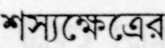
শস্যক্ষেত্রের
